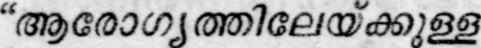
“ആരോഗ്യത്തിലേയ്ക്കുള്ള
